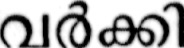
വര്‍ക്കി
